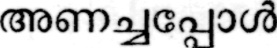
അണച്ചപ്പോള്‍
